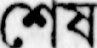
শেষ
